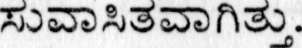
ಸುವಾಸಿತವಾಗಿತ್ತು.
